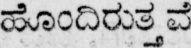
ಹೊಂದಿರುತ್ತವೆ
